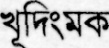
খূদিংমক
